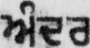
ਅੰਦਰ
